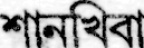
শানখিবা
